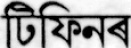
টিফিনৰ
